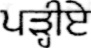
ਪੜ੍ਹੀਏ
